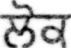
ਲੋਕ
